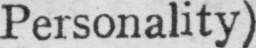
Personality)
